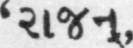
'રાજન્,
